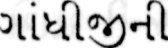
ગાંધીજીની
